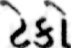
ટેકો
